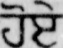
ਹੋਏ
